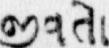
જીવતો
